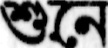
শুনে
